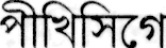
পীখিসিগে
